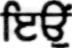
ਇਉਂ
